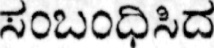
ಸಂಬಂಧಿಸಿದ
